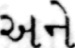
અને
